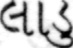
લાડુ
